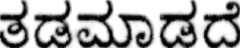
ತಡಮಾಡದೆ
